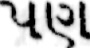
પણ
